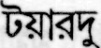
টয়ারদু
